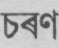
চৰণ
